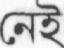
নেই
